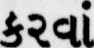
કરવાં
